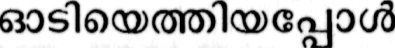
ഓടിയെത്തിയപ്പോള്‍
